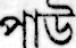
পাউ
